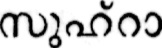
സുഹ്റാ
